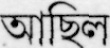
আছিল
